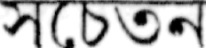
সচেতন
